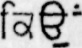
ਕਿਉਂ
